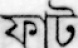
ফাট
